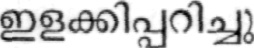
ഇളക്കിപ്പറിച്ചു
